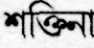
শক্তিনা
